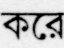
করে
